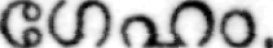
ഗേഹം.
